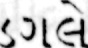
ડગલે
